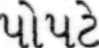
પોપટે
